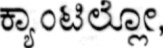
ಕ್ಯಾಂಟಿಲ್ಲೋ,
